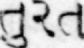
તુરત
